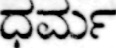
ಧರ್ಮ
